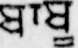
ਬਾਬੂ
